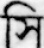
সি
